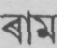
ৰাম
